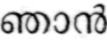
ഞാന്‍
